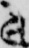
લે
